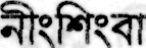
নীংশিংবা
